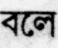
বলে
